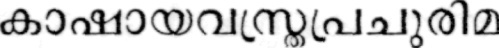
കാഷായവസ്ത്രപ്രചുരിമ
